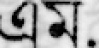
এম.
